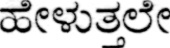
ಹೇಳುತ್ತಲೇ
